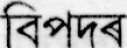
বিপদৰ
